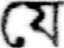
যে
